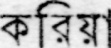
করিয়া
